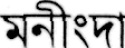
মনীংদা
